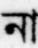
না
